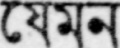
যেমন
